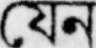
যেন
